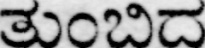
ತುಂಬಿದ
